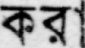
করা
